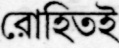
রোহিতই
